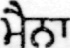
ਮੈਨਾ
